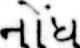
નોંધ
